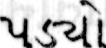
પડ્યો
